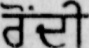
ਰੋਂਦੀ
